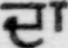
ਦਾ
